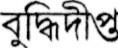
বুদ্ধিদীপ্ত
